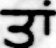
ਤਾਂ
